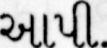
આપી.
